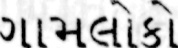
ગામલોકો
